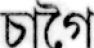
চাগৈ
